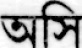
অসি
